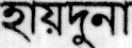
হায়দুনা
